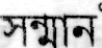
সন্মান
